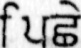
ਪਿਛੇ
